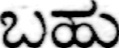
ಬಹು
